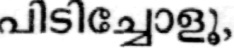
പിടിച്ചോളൂ,
